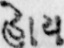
હોય
